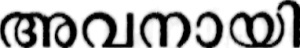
അവനായി
